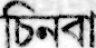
চিনবা
